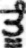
ਤੂੰ
